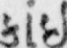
કાંઈ
